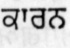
ਕਾਰਨ
